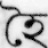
হৈ
